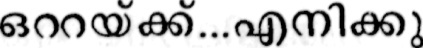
ഒററയ്ക്ക്...എനിക്കു
